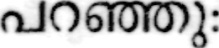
പറഞ്ഞു:
